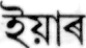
ইয়াৰ
